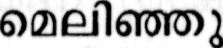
മെലിഞ്ഞു
